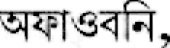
অফাওবনি,
